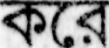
করে
